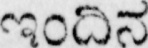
ಇಂದಿನ
